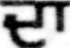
ਦਾ
